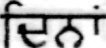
ਦਿਨਾਂ
